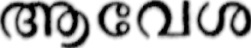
ആവേശ
